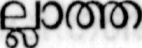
ല്ലാത്ത
